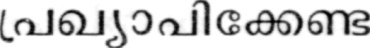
പ്രഖ്യാപിക്കേണ്ട
